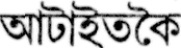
আটাইতকৈ
